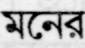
মনের
